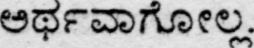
ಅರ್ಥವಾಗೋಲ್ಲ.
